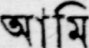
আমি
